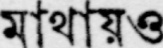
মাথায়ও
